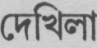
দেখিলা
